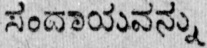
ಸಂದಾಯವನ್ನು
